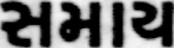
સમાય
